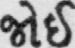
જોઈ
